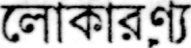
লোকারণ্য
